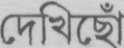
দেখিছোঁ
